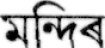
মন্দিৰ
